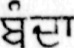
ਬੰਦਾ
